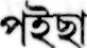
পইছা
